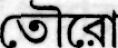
তৌরো
